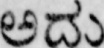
ಅದು
